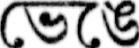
ভেঙে
